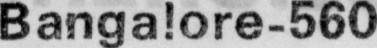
Bangalore-560
